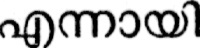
എന്നായി
